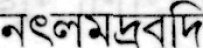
নৎলমদ্রবদি
